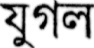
যুগল
